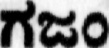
ಗಜಂ
